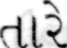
તારે
